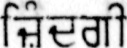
ਜ਼ਿੰਦਗੀ
